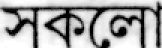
সকলো
